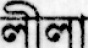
লীলা
